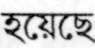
হয়েছে
